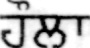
ਹੌਲਾ
